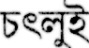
চৎলুই
